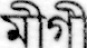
মীগী
